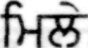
ਮਿਲੇ
